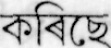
কৰিছে
